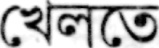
খেলতে
